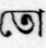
তো
